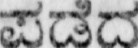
ಪಡೆದ
